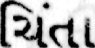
ચિંતા
